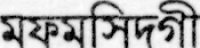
মফমসিদগী
